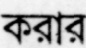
করার
